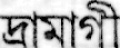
দ্রামাগী
